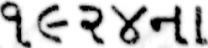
૧૯૨૪ના
